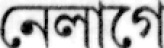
নেলাগে
